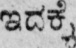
ಇದಕ್ಕೆ
